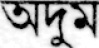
অদুম
